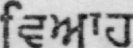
ਵਿਆਹ
